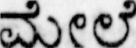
ಮೇಲೆ
